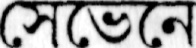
সেভেনে
